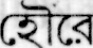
হৌরে
